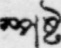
স্পষ্ট
